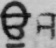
ਉਸ
